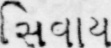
સિવાય
